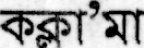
কক্লা’মা
